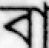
বা
